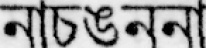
নাচঙননা
